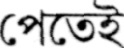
পেতেই
